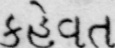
કહેવત
